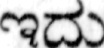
ಇದು
